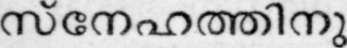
സ്നേഹത്തിനു
